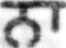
ਨਾ
